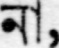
না,
